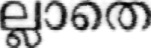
ല്ലാതെ
